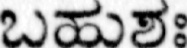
ಬಹುಶಃ
